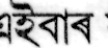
এইবাৰ
